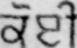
ਕੋਈ
